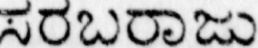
ಸರಬರಾಜು
